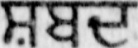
ਸ਼ਬਦ
